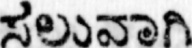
ಸಲುವಾಗಿ
